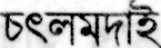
চৎলমদাই
